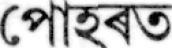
পোহৰত
